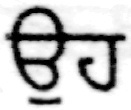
ਉਹ
